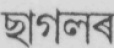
ছাগলৰ
